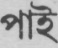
পাই
